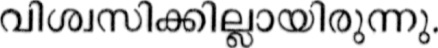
വിശ്വസിക്കില്ലായിരുന്നു.
